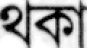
থকা
